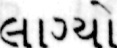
લાગ્યો
